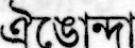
ঐঙোন্দা
